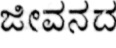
ಜೀವನದ
